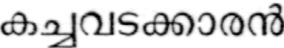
കച്ചവടക്കാരന്‍
